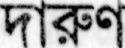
দারুণ
